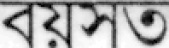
বয়সত
